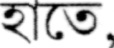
হাতে,
